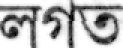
লগত
